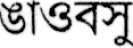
ঙাওবসু
